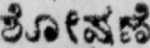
ಶೋಷಣೆ
